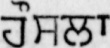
ਹੌਸਲਾ
